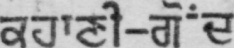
ਕਹਾਣੀ-ਗੋਂਦ
